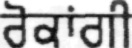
ਰੋਕਾਂਗੀ
